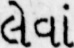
લેવાં
